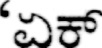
'ಏಕ್
